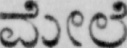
ಮೇಲೆ
